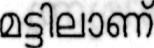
മട്ടിലാണ്
